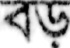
বড়
